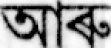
আৰু
